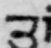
ਤਾਂ
